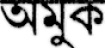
অমুক
